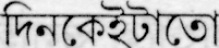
দিনকেইটাতো
